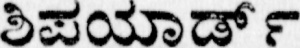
ಶಿಪಯಾರ್ಡ್
